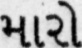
મારો
